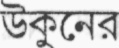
উকুনের
